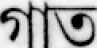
গাত
